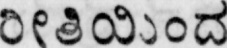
ರೀತಿಯಿಂದ
